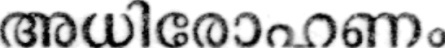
അധിരോഹണം
